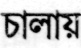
চালায়
